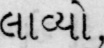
લાવ્યો,
